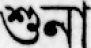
শুনা
